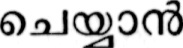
ചെയ്യാന്‍
